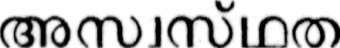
അസ്വസ്ഥത
